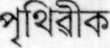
পৃথিৱীক
